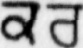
ਕਰ
